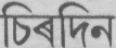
চিৰদিন
